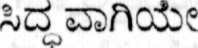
ಸಿದ್ಧವಾಗಿಯೇ
